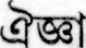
ঐজ্ঞা
